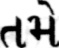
તમે
